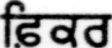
ਫ਼ਿਕਰ
